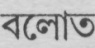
বলোত
